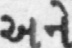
અને
